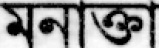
মনাক্তা
